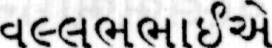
વલ્લભભાઈએ
